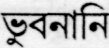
ভুবনানি
